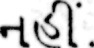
નહીં.
